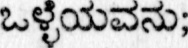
ಒಳ್ಳೆಯವನು;
